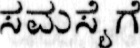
ಸಮಸ್ಯೆಗೆ
